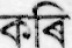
কৰি
